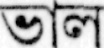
ভাল
